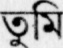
তুমি
